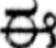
ಈ
